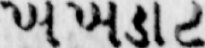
ખખડાટ
